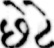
છેટે
